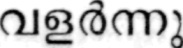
വളര്‍ന്നു
